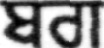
ਬਗ
